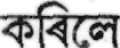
কৰিলে
